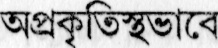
অপ্রকৃতিস্থভাবে
